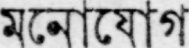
মনোযোগ
